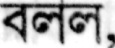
বলল,
